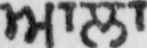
ਆਲਾ
